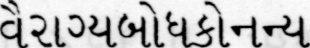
વૈરાગ્યબોધકોનન્ય
